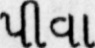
પીવા
